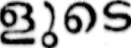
ളുടെ
